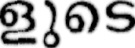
ളുടെ
